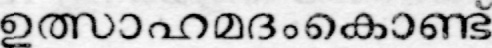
ഉത്സാഹമദംകൊണ്ട്
